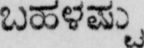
ಬಹಳಷ್ಟು
